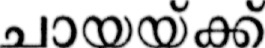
ചായയ്ക്ക്
